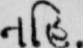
નહિ.
